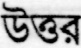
উত্তর
